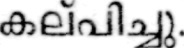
കല്പിച്ചു.
